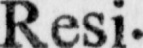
Resi.
